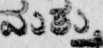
ಮತ್ತು
